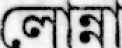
লোন্না
